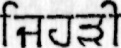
ਜਿਹੜੀ
